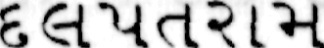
દલપતરામ
